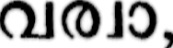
വര്വാ,
